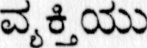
ವ್ಯಕ್ತಿಯು
